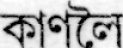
কাণলৈ
